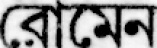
রোমেন
